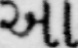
આ
